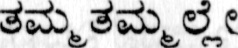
ತಮ್ಮತಮ್ಮಲ್ಲೇ
